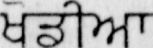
ਖੋਡੀਆ
